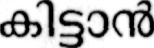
കിട്ടാന്‍
